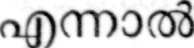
എന്നാല്‍
